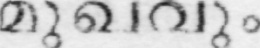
മുഖവും
